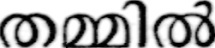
തമ്മില്‍
